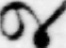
જ
